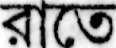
রাতে
